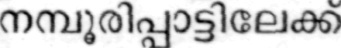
നമ്പൂരിപ്പാട്ടിലേക്ക്
